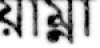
য়াম্না
